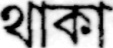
থাকা
